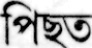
পিছত
